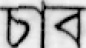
চাব
